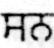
ਸਨ
